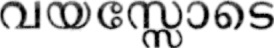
വയസ്സോടെ
